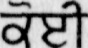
ਕੋਈ
